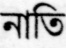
নাতি
